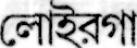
লোইরগা
